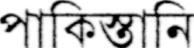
পাকিস্তানি
